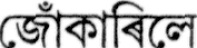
জোঁকাৰিলে
